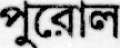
পুরোল
